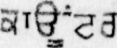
ਕਾਊਂਟਰ
